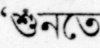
‘শুনতে
